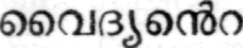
വൈദ്യന്റെ
